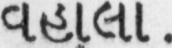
વહાલા.
